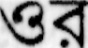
ওর
